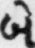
બે
